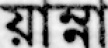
য়াম্না
